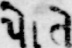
પોતે
